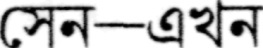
সেন–এখন
